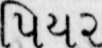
પિયર
